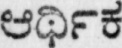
ಆರ್ಥಿಕ
